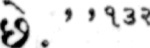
છે."૧૩૨
